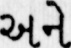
અને
